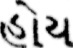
હોય
